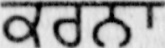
ਕਰਨਾ
